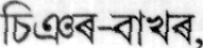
চিঞৰ-বাখৰ,
